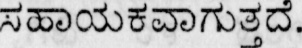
ಸಹಾಯಕವಾಗುತ್ತದೆ.
